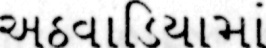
અઠવાડિયામાં
